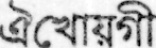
ঐখোয়গী
